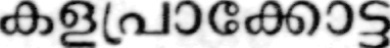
കളപ്രാക്കോട്ട
